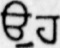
ਉਹ
